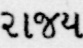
રાજ્ય
